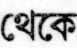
থেকে
